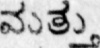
ಮತ್ತು
